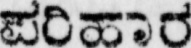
ಪರಿಹಾರ
